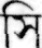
সি
